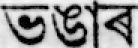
ভঙাৰ
